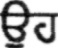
ਉਹ
